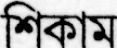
শিকাম
